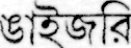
ঙাইজরি
